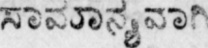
ಸಾಮಾನ್ಯವಾಗಿ
